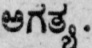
ಅಗತ್ಯ.
